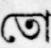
তো
